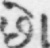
છો
